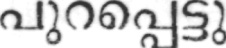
പുറപ്പെട്ടു
